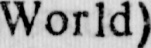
World)
